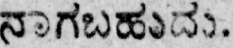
ನಾಗಬಹುದು.
